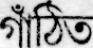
গাঁঠিত
